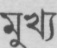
মুখ্য
